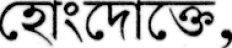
হোংদোক্তে,
